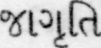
જાગૃતિ
